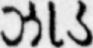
ઝાડ
